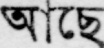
আছে
